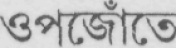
ওপজোঁতে
